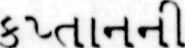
કપ્તાનની
